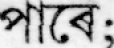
পাৰে;
